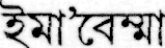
ইমা’বেম্মা
